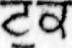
ਟੁਕ
